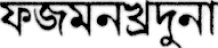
ফজমনখ্রদুনা
